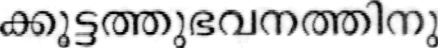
ക്കൂട്ടത്തുഭവനത്തിനു
